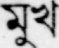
মুখ
